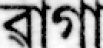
ৱাগা
